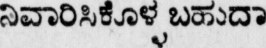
ನಿವಾರಿಸಿಕೊಳ್ಳಬಹುದಾ
